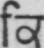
ਕਿ
